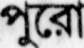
পুরো
